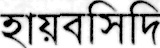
হায়বসিদি
